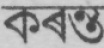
কৰন্ত
